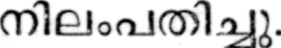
നിലംപതിച്ചു.
